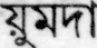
য়ুমদা
